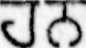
ਹਨ
